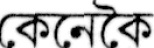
কেনেকৈ
